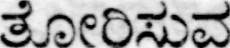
ತೋರಿಸುವ
